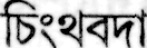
চিংথবদা
